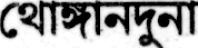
থোঙ্গানদুনা
